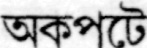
অকপটে
